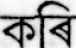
কৰি
